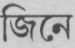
জিনে
